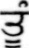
ਤੂੰ
